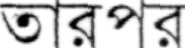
তারপর
